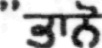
''ਭਾਨੋ
